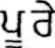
ਪੂਰੇ
